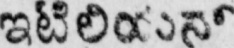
ಇಟೆಲಿಯನ್
